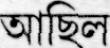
আছিল
